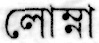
লোম্না
